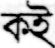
কই
